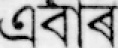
এবাৰ
